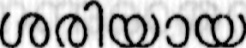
ശരിയായ
